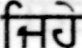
ਜਿਹੇ
